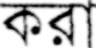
করা
